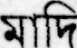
মাদি
